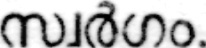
സ്വര്‍ഗം.
